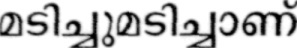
മടിച്ചുമടിച്ചാണ്
